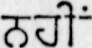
ਨਹੀਂ
